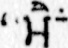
'ਮੈਂ
